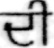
ਦੀ
